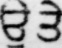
ਉਤੇ
